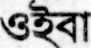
ওইবা
